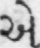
એ
